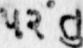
પરંતુ
